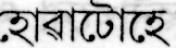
হোৱাটোহে
